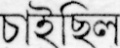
চাইছিল
